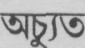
অচ্যুত
